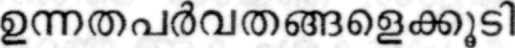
ഉന്നതപര്‍വതങ്ങളെക്കൂടി
